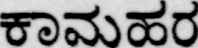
ಕಾಮಹರ
